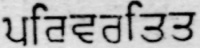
ਪਰਿਵਰਤਿਤ
